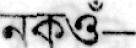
নকওঁ-
